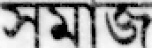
সমাজ
